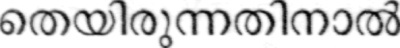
തെയിരുന്നതിനാല്‍
